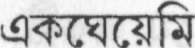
একঘেয়েমি
